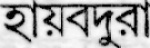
হায়বদুরা
